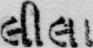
લીલા
